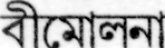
বীমোলনা
